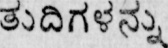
ತುದಿಗಳನ್ನು
